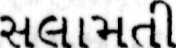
સલામતી
